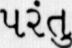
પરંતુ
